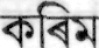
কৰিম
